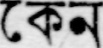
কেন
